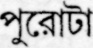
পুরোটা
